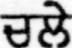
ਚਲੇ
